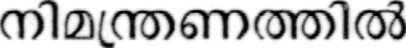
നിമന്ത്രണത്തില്‍
